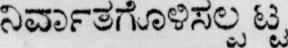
ನಿರ್ವಾತಗೊಳಿಸಲ್ಪಟ್ಟ
